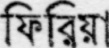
ফিরিয়া
